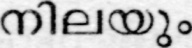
നിലയും
